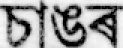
চাঙৰ
